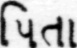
પિતા
